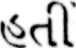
હતી
